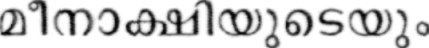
മീനാക്ഷിയുടെയും
